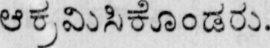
ಆಕ್ರಮಿಸಿಕೊಂಡರು.
